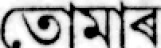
তোমাৰ
